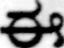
ಈ
